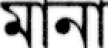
মানা
